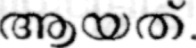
ആയത്.
